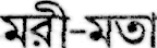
মরী-মতা
